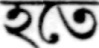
হতে
